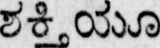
ಶಕ್ತಿಯೂ
